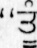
''ਤੂੰ
